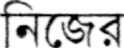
নিজের
